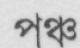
পঞ্চ
